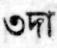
৩দা
